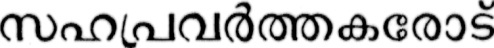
സഹപ്രവര്‍ത്തകരോട്
